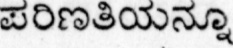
ಪರಿಣತಿಯನ್ನೂ
